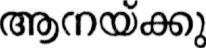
ആനയ്ക്കു
